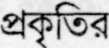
প্রকৃতির
